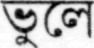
ভুলে
